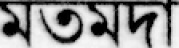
মতমদা
